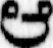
ಆ
